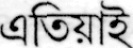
এতিয়াই
